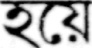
হয়ে
